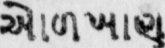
ઓળખાણ
